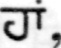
ਹਾਂ,
